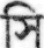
সি
